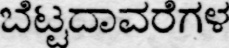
ಬೆಟ್ಟದಾವರೆಗಳ
